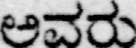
ಅವರು
